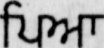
ਪਿਆ
